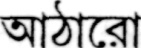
আঠারো
